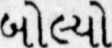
બોલ્યો
